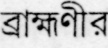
ব্রাহ্মণীর
